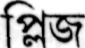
প্লিজ
